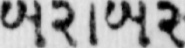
બરાબર
